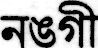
নঙগী
